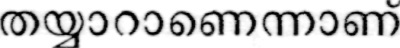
തയ്യാറാണെന്നാണ്
